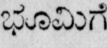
ಭೂಮಿಗೆ
